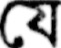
যে
